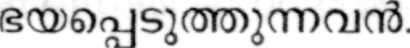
ഭയപ്പെടുത്തുന്നവന്‍.
